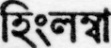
হিংলম্বা
